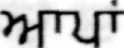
ਆਪਾਂ
